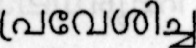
പ്രവേശിച്ച
